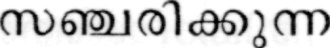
സഞ്ചരിക്കുന്ന
